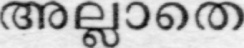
അല്ലാതെ
